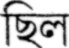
ছিল
